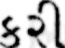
કરી
